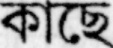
কাছে
